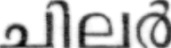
ചിലര്‍
